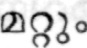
മറ്റും
